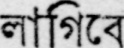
লাগিবে
